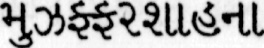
મુઝફ્ફરશાહના
